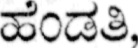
ಹೆಂಡತಿ,
